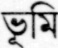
ভূমি
